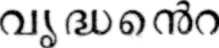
വൃദ്ധന്റെ
